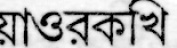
য়াওরকখি
